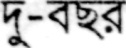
দু-বছর
